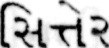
સિત્તેર
